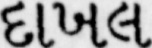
દાખલ
